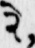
રે,
